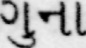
ગુના
